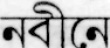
নবীনে
